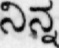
ನಿನ್ನ
